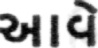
આવે
